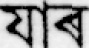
যাৰ
